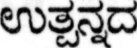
ಉತ್ಪನ್ನದ
